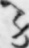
કે
